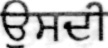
ਉਸਦੀ
